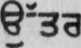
ਉੱਤਰ
